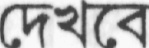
দেখবে
